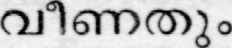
വീണതും
